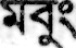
মবুং
